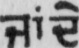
ਜਾਂਦੇ
